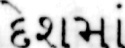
દેશમાં
